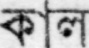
কাল
